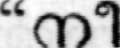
"നീ
